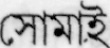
সোমাই
